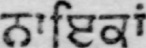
ਨਾਇਕਾਂ
